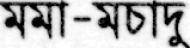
মমা-মচাদু
